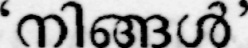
'നിങ്ങള്‍'
